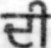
ਦੀ
